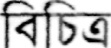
বিচিত্র
